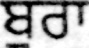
ਬੁਰਾ
